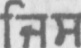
ਜਿਸ
